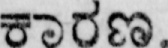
ಕಾರಣ.
